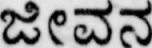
ಜೀವನ
